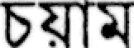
চয়াম
